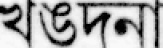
খঙদনা
